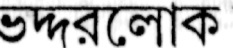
ভদ্দরলোক
